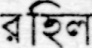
রহিল
